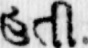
હતી.
